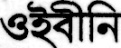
ওইবীনি
